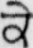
ਕੇ
